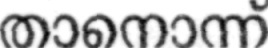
താനൊന്ന്
